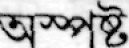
অস্পষ্ট
